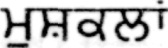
ਮੁਸ਼ਕਲਾਂ
